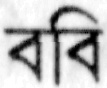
ববি
